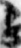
કે
